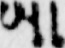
બા
